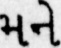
મને
